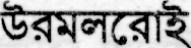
উরমলরোই
